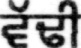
ਵੱਢੀ
